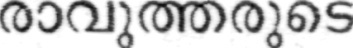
രാവുത്തരുടെ
